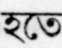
হতে
